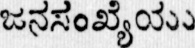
ಜನಸಂಖ್ಯೆಯು
